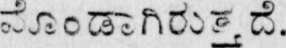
ಮೊಂಡಾಗಿರುತ್ತದೆ.
